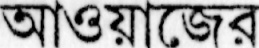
আওয়াজের
